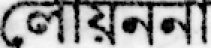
লোয়ননা
